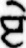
ਏ
